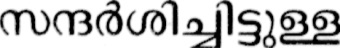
സന്ദര്‍ശിച്ചിട്ടുള്ള
